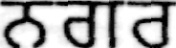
ਨਗਰ
